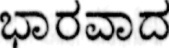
ಭಾರವಾದ
